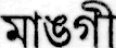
মাঙগী
